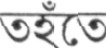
তহঁতে
